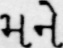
મને
